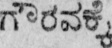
ಗೌರವಕ್ಕೆ
